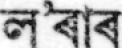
ল'ৰাৰ
